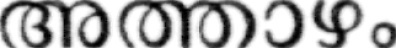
അത്താഴം
